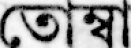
তোম্বা
